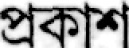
প্রকাশ
